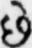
છે
